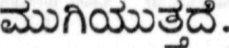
ಮುಗಿಯುತ್ತದೆ.
